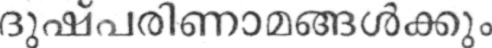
ദുഷ്പരിണാമങ്ങള്‍ക്കും
